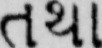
તથા
